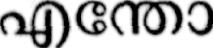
എന്തോ
